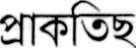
প্রাকতিছ
